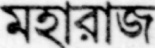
মহারাজ
